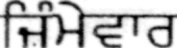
ਜ਼ਿੰਮੇਵਾਰ
